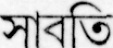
সাবতি
